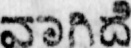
ವಾಗಿದೆ
